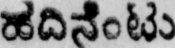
ಹದಿನೆಂಟು
